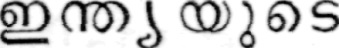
ഇന്ത്യയുടെ
